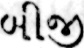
બીજી
